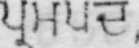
ਪ੍ਰਮਪਦ,
